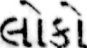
લોકો
